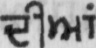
ਦੀਆਂ
